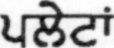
ਪਲੇਟਾਂ
